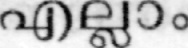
എല്ലാം
